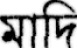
মাদি
